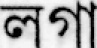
লগা
